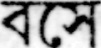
বসে
